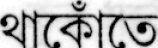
থাকোঁতে
